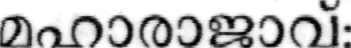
മഹാരാജാവ്:
